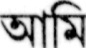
আমি
